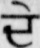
ਦੇ
